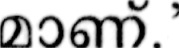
മാണ്.’
